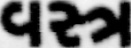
વસ્ત્ર
